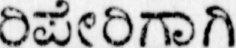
ರಿಪೇರಿಗಾಗಿ
